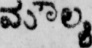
ಮೌಲ್ಯ
